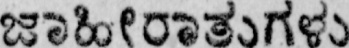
ಜಾಹೀರಾತುಗಳು
